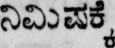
ನಿಮಿಷಕ್ಕೆ
